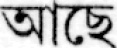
আছে
